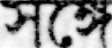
সঙ্গে
